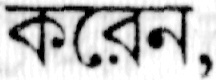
করেন,
